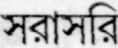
সরাসরি
